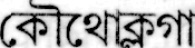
কৌথোক্লগা
